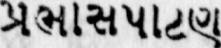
પ્રભાસપાટણ
